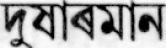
দুষাৰমান
